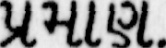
પ્રમાણ.
